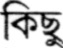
কিছু
